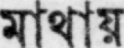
মাথায়
